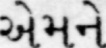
એમને
